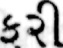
ફરી
